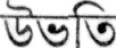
উভতি
